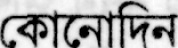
কোনোদিন
